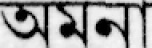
অমনা
